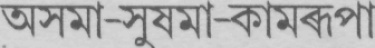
অসমা-সুষমা-কামৰূপা
